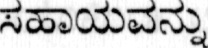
ಸಹಾಯವನ್ನು
